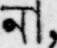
না,
